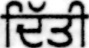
ਦਿੱਤੀ
